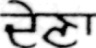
ਦੇਣਾ
